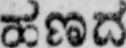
ಹಣದ
